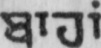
ਬਾਹਾਂ
